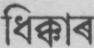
ধিক্কাৰ
